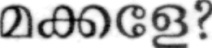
മക്കളേ?
